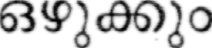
ഒഴുക്കും
